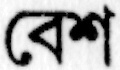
বেশ
